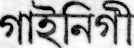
গাইনিগী
